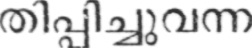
തിപ്പിച്ചുവന്ന
